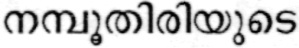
നമ്പൂതിരിയുടെ
